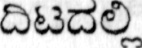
ದಿಟದಲ್ಲಿ
